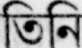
তিনি
